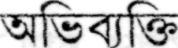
অভিব্যক্তি
